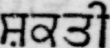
ਸ਼ਕਤੀ
